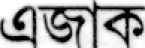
এজাক
